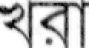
খরা
